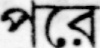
পরে
